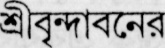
শ্রীবৃন্দাবনের
